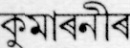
কুমাৰনীৰ
